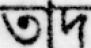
তাদ
